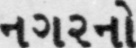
નગરનો
